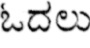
ಓದಲು
